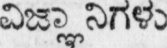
ವಿಜ್ಞಾನಿಗಳು
